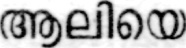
ആലിയെ
